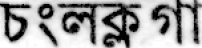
চংলক্লগা
